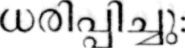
ധരിപ്പിച്ചു:
